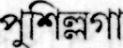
পুশিল্লগা
